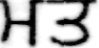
ਮਤ
